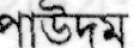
পাউদম
